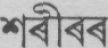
শৰীৰৰ
